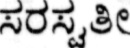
ಸರಸ್ವತೀ
